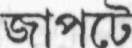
জাপটে
